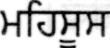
ਮਹਿਸੂਸ
